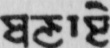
ਬਣਾਏ
